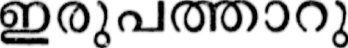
ഇരുപത്താറു
